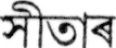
সীতাৰ
